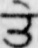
ਤੇ
